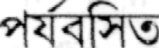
পর্যবসিত
